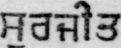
ਸੁਰਜੀਤ
